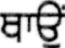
ਥਾਉਂ
